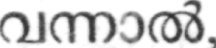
വന്നാല്‍,
